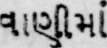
વાણીમાં
